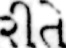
રીતે
